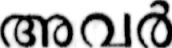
അവര്‍
